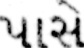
પાસે
